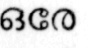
ഒരേ
